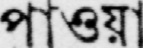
পাওয়া
